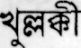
খুল্লক্কী
